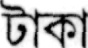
টাকা
